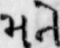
મને
